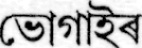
ভোগাইৰ
